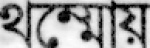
থম্মোয়
